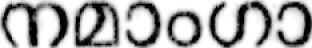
നമാംഗാ
